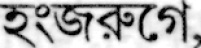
হংজরুগে,
